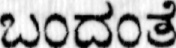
ಬಂದಂತೆ
